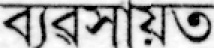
ব্যৱসায়ত
